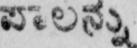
ಪಾಲನ್ನು
